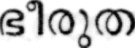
ഭീരുത
